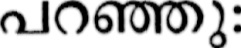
പറഞ്ഞു:
